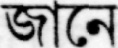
জানে
